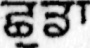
ਛੁਡਾ
